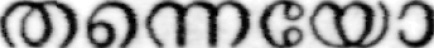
തന്നെയോ
